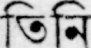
তিনি
